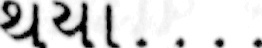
થયા....
